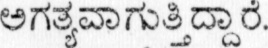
ಅಗತ್ಯವಾಗುತ್ತಿದ್ದಾರೆ.
